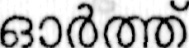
ഓര്‍ത്ത്
